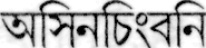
অসিনচিংবনি
